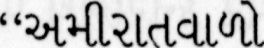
"અમીરાતવાળો
